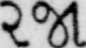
રજા
